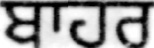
ਬਾਹਰ
